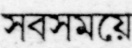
সবসময়ে
